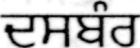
ਦਸੰਬਰ
